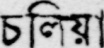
চলিয়া
